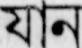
যান
